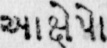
આક્ષેપો
